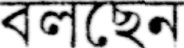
বলছেন
